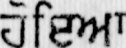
ਹੋਇਆ
